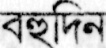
বহুদিন
